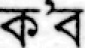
ক'ব
